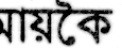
মায়কৈ
